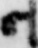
ન
